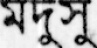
মদুসু
